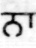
ਨਾ
